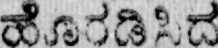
ಹೊರಡಿಸಿದ
